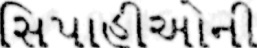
સિપાહીઓની
